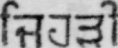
ਜਿਹੜੀ
